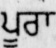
ਪੂਰਾ
